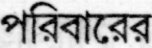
পরিবারের
